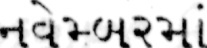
નવેમ્બરમાં
